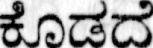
ಕೊಡದೆ
